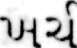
ખર્ચ
